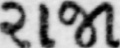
રાજા
